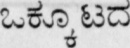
ಒಕ್ಕೂಟದ
